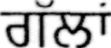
ਗੱਲਾਂ
